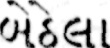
બેઠેલા
